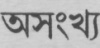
অসংখ্য
